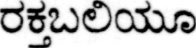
ರಕ್ತಬಲಿಯೂ
